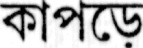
কাপড়ে
